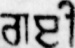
ਗਈ
